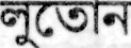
লুতোন
